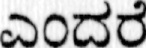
ಎಂದರೆ
